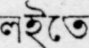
লইতে
